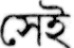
সেই
